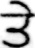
ਤੇ
